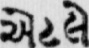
એટલે
